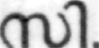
സി.
